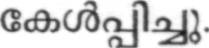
കേള്‍പ്പിച്ചു.
